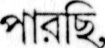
পারছি,
